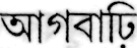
আগবাঢ়ি
